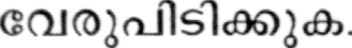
വേരുപിടിക്കുക.
